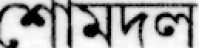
শোমদল
